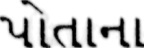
પોતાના
